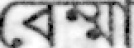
বেম্মা
